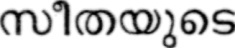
സീതയുടെ
